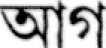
আগ
